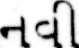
નવી
